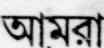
আমরা
